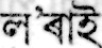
ল'ৰাই
